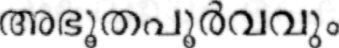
അഭൂതപൂര്‍വവും
